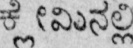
ಕ್ಲೇಮಿನಲ್ಲಿ
